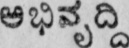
ಅಭಿವೃದ್ಧಿ
